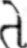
તે
